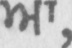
ਆ,
